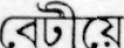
বেটীয়ে
